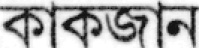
কাকজান
